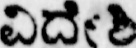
ವಿದೇಶಿ
